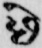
છે
